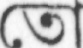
তো
